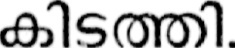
കിടത്തി.
